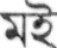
মই
